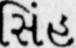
સિંહ
